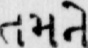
તમને
